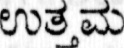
ಉತ್ತಮ
